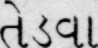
તેડવા
